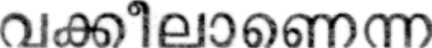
വക്കീലാണെന്ന
